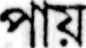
পায়
